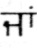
ਜਾਂ
